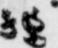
કહું
